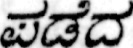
ಪಡೆದ
